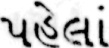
પહેલાં
